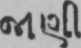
જાણી
